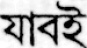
যাবই
